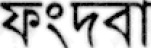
ফংদবা
